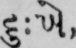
દુઃખે,
